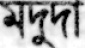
মদুদা
